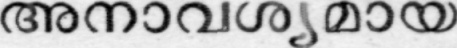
അനാവശ്യമായ
